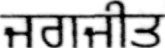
ਜਗਜੀਤ
